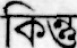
কিন্তু
